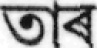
তাৰ
